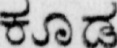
ಕೂಡ
